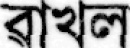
ৱাখল
